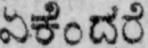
ಏಕೆಂದರೆ
